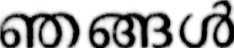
ഞങ്ങള്‍
